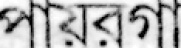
পায়রগা
